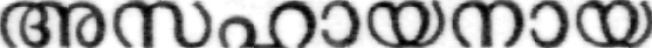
അസഹായനായ
